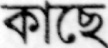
কাছে
